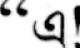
“এ!
